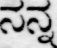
ನನ್ನ
